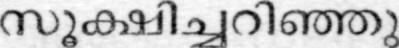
സൂക്ഷിച്ചറിഞ്ഞു
